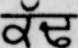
ਕੱਢ
